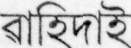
ৱাহিদাই
